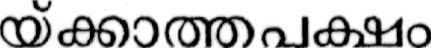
യ്ക്കാത്തപക്ഷം
